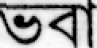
ভবা
